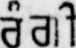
ਰੰਗੀ
